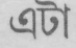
এটা
